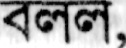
বলল,
